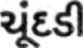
ચૂંદડી
